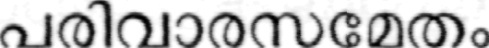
പരിവാരസമേതം
